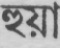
হুয়া
